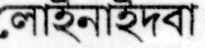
লোইনাইদবা
